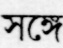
সঙ্গে
